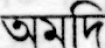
অমদি
